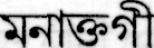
মনাক্তগী
